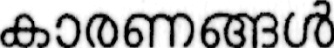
കാരണങ്ങള്‍
